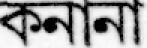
কনানা
